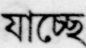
যাচ্ছে
